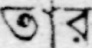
তার
